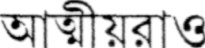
আত্মীয়রাও
